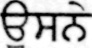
ਉਸਨੇ
